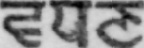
ਵਧਣ
